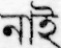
নাই
